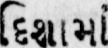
દિશામા
